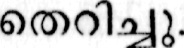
തെറിച്ചു.
